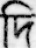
দি
